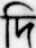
দি
